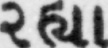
રહ્યા
